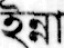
ইন্না
